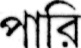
পারি
